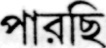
পারছি
